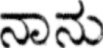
ನಾನು
